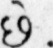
છે.
